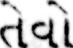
તેવો
